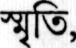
স্মৃতি,
